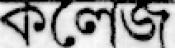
কলেজ
